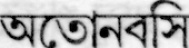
অতোনবসি
